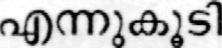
എന്നുകൂടി
